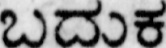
ಬದುಕ
